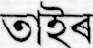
তাইৰ
